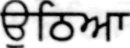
ਉਠਿਆ
